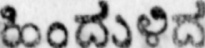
ಹಿಂದುಳಿದ
